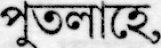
পুতলাহে,
